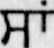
ਸਾਂ
